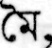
মৈ,
